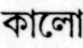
কালো
